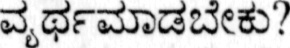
ವ್ಯರ್ಥಮಾಡಬೇಕು?
